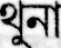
থুনা
